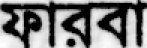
ফারবা
